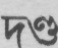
দণ্ড
